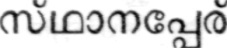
സ്ഥാനപ്പേര്
